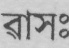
ৱাসঃ
